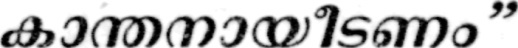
കാന്തനായീടണം”
